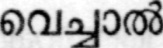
വെച്ചാല്‍
